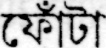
ফোঁটা
